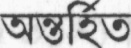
অন্তর্হিত
